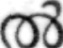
ല്‍
